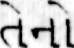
તેનો
